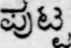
ಪುಟ್ಟ
